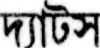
দ্যাটস
